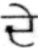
ਦੇ
